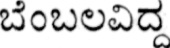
ಬೆಂಬಲವಿದ್ದ
